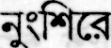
নুংশিরে
